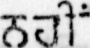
ਨਹੀਂ
